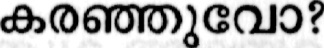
കരഞ്ഞുവോ?
